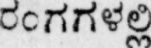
ರಂಗಗಳಲ್ಲಿ
